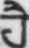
ਹੈ
